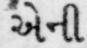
એની
